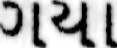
ગયા
